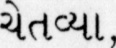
ચેતવ્યા,
